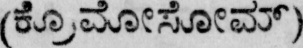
(ಕ್ರೋಮೋಸೋಮ್)
